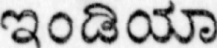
ಇಂಡಿಯಾ
